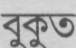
বুকুত
